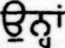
ਉਨ੍ਹਾਂ
